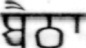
ਬੈਠਾ
